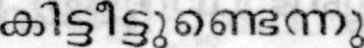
കിട്ടീട്ടുണ്ടെന്നു
